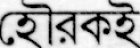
হৌরকই
